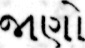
જાણો
